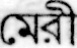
মেরী
